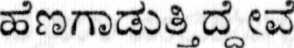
ಹೆಣಗಾಡುತ್ತಿದ್ದೇವೆ
